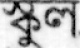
স্কুল
